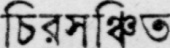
চিরসঞ্চিত
